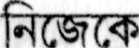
নিজেকে
